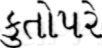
કુતોપરે
